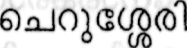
ചെറുശ്ശേരി
